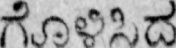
ಗೊಳಿಸಿದ
